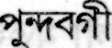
পুন্দবগী
